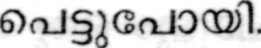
പെട്ടുപോയി.
